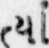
ત્યાં
